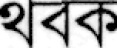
থবক
